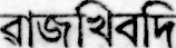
ৱাজখিবদি
